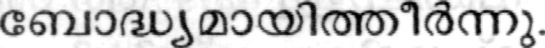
ബോദ്ധ്യമായിത്തീര്‍ന്നു.
